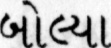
બોલ્યા
